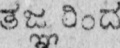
ತಜ್ಞರಿಂದ
